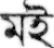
মই
